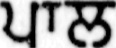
ਪਾਲ
